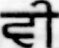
ਵੀ
